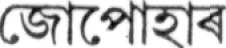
জোপোহাৰ
